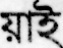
য়াই
